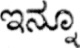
ಇನ್ನೂ
